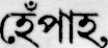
হেঁপাহ,
